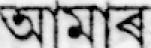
আমাৰ
